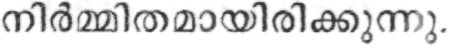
നിര്‍മ്മിതമായിരിക്കുന്നു.
